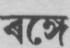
ৰঙ্গে
